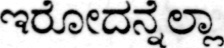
ಇರೋದನ್ನೆಲ್ಲಾ
